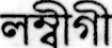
লম্বীগী
